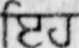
ਇਹ
